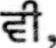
ਵੀ,
